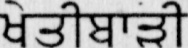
ਖੇਤੀਬਾੜੀ
